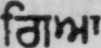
ਗਿਆ
